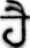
ਹੈ
